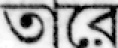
তারে
